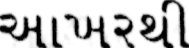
આખરથી
